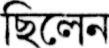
ছিলেন
